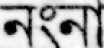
নংনা
